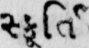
સ્ફૂર્તિ
